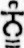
ਨੂੰ
